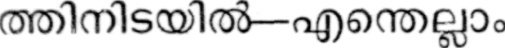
ത്തിനിടയില്‍-എന്തെല്ലാം
